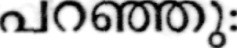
പറഞ്ഞു:
